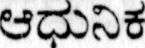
ಆಧುನಿಕ
